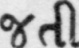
જતી
